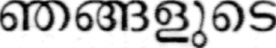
ഞങ്ങളുടെ
